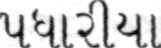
પધારીયા
